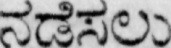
ನಡೆಸಲು
